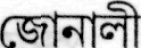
জোনালী
